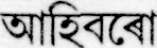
আহিবৰো
